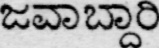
ಜವಾಬ್ದಾರಿ
